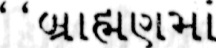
"બ્રાહ્મણમાં
